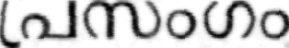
പ്രസംഗം
